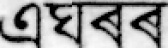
এঘৰৰ
